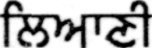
ਲਿਆਣੀ
